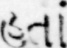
હતાં
